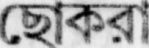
ছোকরা
